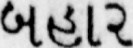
બહાર
